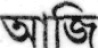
আজি
